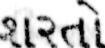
શરતો
